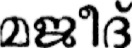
മജീദ്
